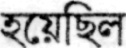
হয়েছিল
